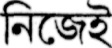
নিজেই
